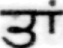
ਤਾਂ
